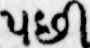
પછી
